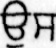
ਉਸ
